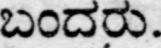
ಬಂದರು.
